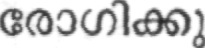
രോഗിക്കു
